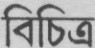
বিচিত্ৰ
